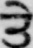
ਤੇ
